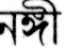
নঙ্গী
